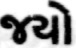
જયો
